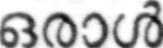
ഒരാള്‍
